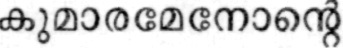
കുമാരമേനോന്റെ
